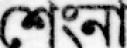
শেংনা
